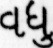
વધુ
